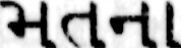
મતના
